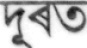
দূৰত
